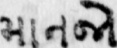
માનજો
